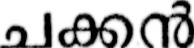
ചക്കന്‍
